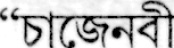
“চাজেনবী
